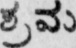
ಶ್ರಮ
